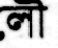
লৌ
